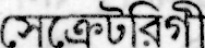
সেক্রেটরিগী
